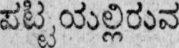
ಪಟ್ಟಿಯಲ್ಲಿರುವ
